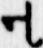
ન
